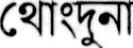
থোংদুনা
